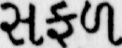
સફળ
